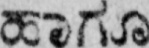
ಹಾಗೂ
